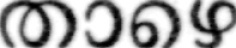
താഴെ
